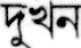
দুখন
